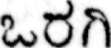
ಒರಗಿ
